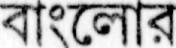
বাংলোর
